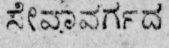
ಸೇವಾವರ್ಗದ
